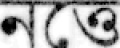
নত্তে
